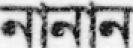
নানান
